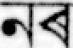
নৰ
